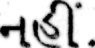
નહીં.
